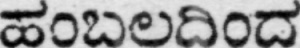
ಹಂಬಲದಿಂದ
